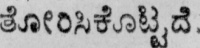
ತೋರಿಸಿಕೊಟ್ಟಿದೆ.
